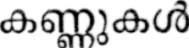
കണ്ണുകള്‍
